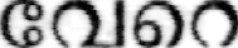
വേറെ
